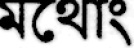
মথোং
